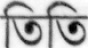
তিতি
